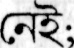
নেই;
